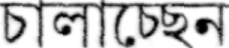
চালাচ্ছেন
